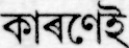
কাৰণেই
